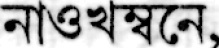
নাওখম্বনে,
